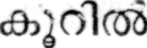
കൂറില്‍
